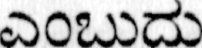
ಎಂಬುದು
